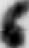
માત્ર'
